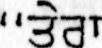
''ਤੇਰਾ
